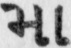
મા
